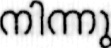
നിന്നു
